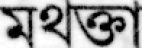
মথক্তা
